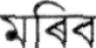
মৰিব
